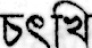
চৎখি
